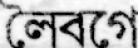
লৈবগে
